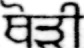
ਥੋੜੀ
